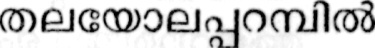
തലയോലപ്പറമ്പില്‍
